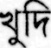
খুদি
